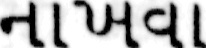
નાખવા
